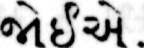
જોઇએ.
